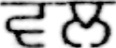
ਵਲ
